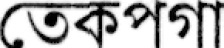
তেকপগা
